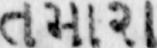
તમારા
